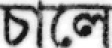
চালে
